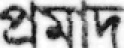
প্রমাদ
